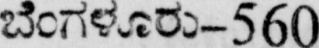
ಬೆಂಗಳೂರು-560
